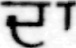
ਦਾ
